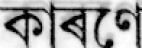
কাৰণে
